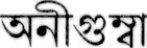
অনীগুম্বা
